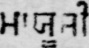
ਮਾਯੂਸੀ
